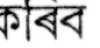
কৰিব
